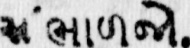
સંભાળજો.
